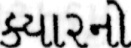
ક્યારનો
